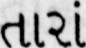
તારાં
